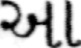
આ
